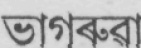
ভাগৰুৱা
